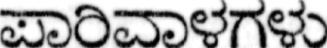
ಪಾರಿವಾಳಗಳು
